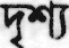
দৃশ্য
